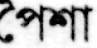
পৈশা
